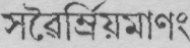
সৱৈৰ্ম্ৰিয়মাণং
